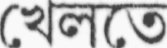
খেলতে
